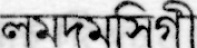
লমদমসিগী
